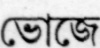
ভোজে
